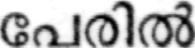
പേരില്‍
